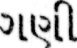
ગણી
